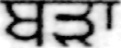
ਬੜਾ
